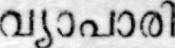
വ്യാപാരി
